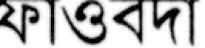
ফাওবদা
